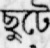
ছুটে
